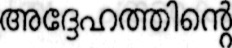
അദ്ദേഹത്തിന്റെ
